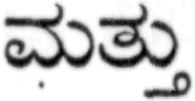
ಮತ್ತು
